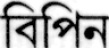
বিপিন
